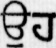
ਉਹ
